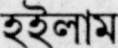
হইলাম
